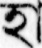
হা
